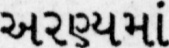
અરણ્યમાં
